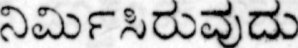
ನಿರ್ಮಿಸಿರುವುದು
